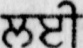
ਲਈ
